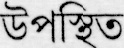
উপস্থিত
